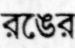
রঙের
